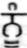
ਨੂੰ
